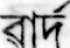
ৱার্দ
